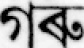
গৰু
